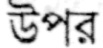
উপর
